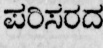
ಪರಿಸರದ
